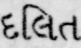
દલિત
